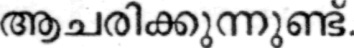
ആചരിക്കുന്നുണ്ട്.
